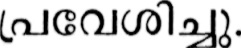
പ്രവേശിച്ചു.
